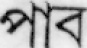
পাব
